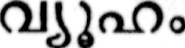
വ്യൂഹം
